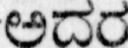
ಅದರ
